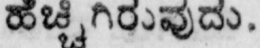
ಹಚ್ಚಿಗಿರುವುದು.
